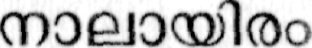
നാലായിരം
